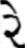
રે
